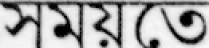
সময়তে
